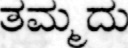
ತಮ್ಮದು
